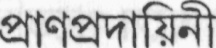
প্রাণপ্রদায়িনী
